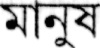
মানুষ
